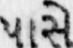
પાસે
